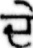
ਦੇ
